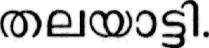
തലയാട്ടി.
